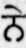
ਨੇ
